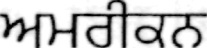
ਅਮਰੀਕਨ
